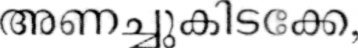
അണച്ചുകിടക്കേ,
